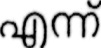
എന്ന്
